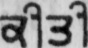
ਕੀਤੀ
